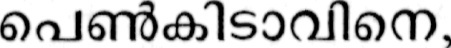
പെണ്‍കിടാവിനെ,
